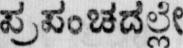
ಪ್ರಪಂಚದಲ್ಲೇ
